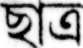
ছাত্র
